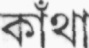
কাঁথা
